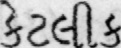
કેટલીક
